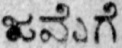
ಜಮೆಗೆ
